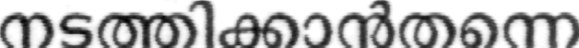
നടത്തിക്കാന്‍തന്നെ
